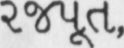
રજપૂત,
